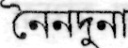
নৈনদুনা
